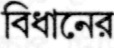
বিধানের
